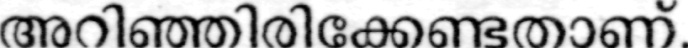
അറിഞ്ഞിരിക്കേണ്ടതാണ്.
